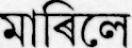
মাৰিলে
